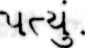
પત્યું,
